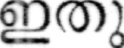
ഇതു
